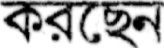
করছেন
